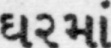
ઘરમાં
